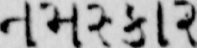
નમસ્કાર
